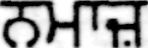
ਨਮਾਜ਼
